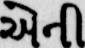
એની
